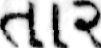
તાર
